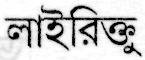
লাইরিক্তু
